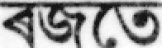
ৰজতে
